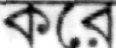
করে
